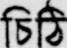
চিঠি
